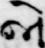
જો
